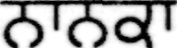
ਨਾਨਕਾ
